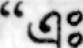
"এঃ
